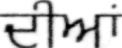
ਦੀਆਂ
